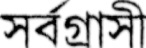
সর্বগ্রাসী
